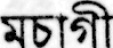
মচাগী
